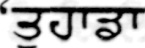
'ਤੁਹਾਡਾ
